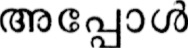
അപ്പോള്‍
